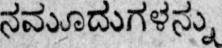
ನಮೂದುಗಳನ್ನು
